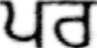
ਪਰ
